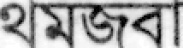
থমজবা
